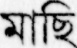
মাছি
